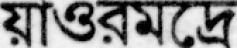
য়াওরমদ্রে
